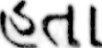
હતા
